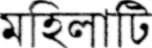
মহিলাটি
